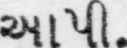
આપી.
